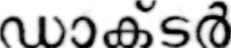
ഡാക്ടര്‍
